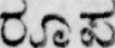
ರೂಪ
